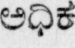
ಅಧಿಕ
